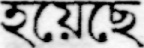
হয়েছে
